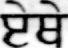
ਏਥੇ
